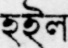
হইল
